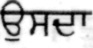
ਉਸਦਾ
